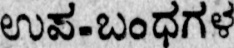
ಉಪ-ಬಂಧಗಳ
